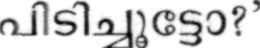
പിടിച്ചൂട്ടോ?'
